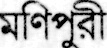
মণিপুরী
